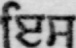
ਇਸ
